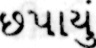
છપાયું
